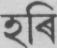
হৰি
